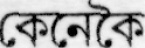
কেনেকৈ
